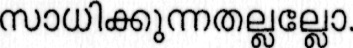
സാധിക്കുന്നതല്ലല്ലോ.
